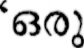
'ഒരു
